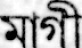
মাগী
